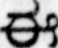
ಈ
